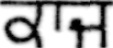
ਕਾਜ
